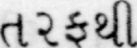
તરફથી
